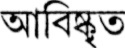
আবিষ্কৃত
